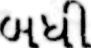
બધી
